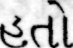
હતો
